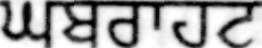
ਘਬਰਾਹਟ
